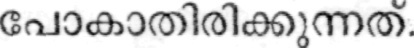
പോകാതിരിക്കുന്നത്.
